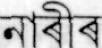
নাৰীৰ
